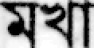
মখা
